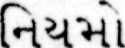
નિયમો
